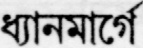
ধ্যানমার্গে
